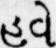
હવે
